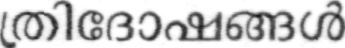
ത്രിദോഷങ്ങള്‍
